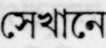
সেখানে
